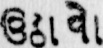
ઉઠાવો
